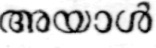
അയാള്‍
